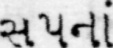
સપનાં
